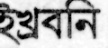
ইখ্রবনি
